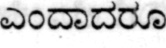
ಎಂದಾದರೂ
